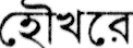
হৌখরে
